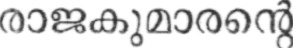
രാജകുമാരന്റെ
